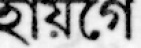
হায়গে
